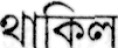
থাকিল
